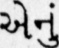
એનું
